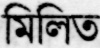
মিলিত
